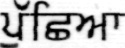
ਪੁੱਛਿਆ
